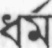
ধর্ম
